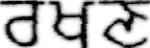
ਰਖਣ
